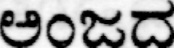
ಅಂಜದ
